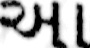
આ
